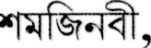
শমজিনবী,
